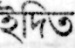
ইদিত
